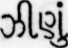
ઝીણું
